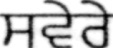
ਸਵੇਰੇ
